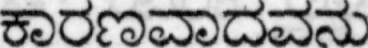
ಕಾರಣವಾದವನು
